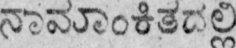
ನಾಮಾಂಕಿತದಲ್ಲಿ
